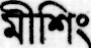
মীশিং
